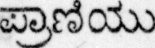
ಪ್ರಾಣಿಯು
